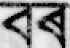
বৰ
